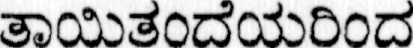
ತಾಯಿತಂದೆಯರಿಂದ
